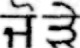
ਜੋੜੇ
